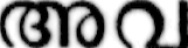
അവ
